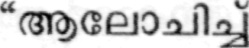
“ആലോചിച്ച്
